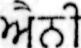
ਐਨੀ
